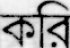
করি
